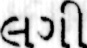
લગી
